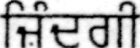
ਜ਼ਿੰਦਗੀ
